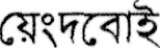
য়েংদবোই
